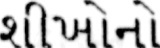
શીખોનો
